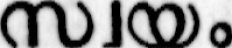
സ്വയം
